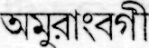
অমুরাংবগী
